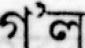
গ'ল
